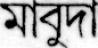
মাবুদা
